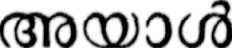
അയാള്‍
